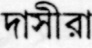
দাসীরা
